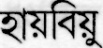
হায়বিয়ু
